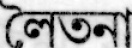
লৈতনা
